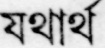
যথার্থ
